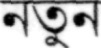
নতুন
